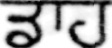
ਡਾਹ
